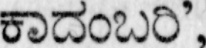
ಕಾದಂಬರಿ’,
